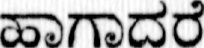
ಹಾಗಾದರೆ
